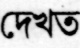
দেখত
